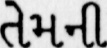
તેમની
